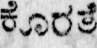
ಕೊರತೆ
